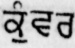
ਕੁੰਵਰ
